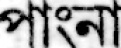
পাংনা
